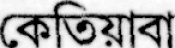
কেতিয়াবা
